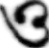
ও
